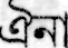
ঐনা
